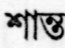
শান্ত
